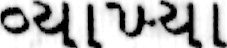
વ્યાખ્યા
